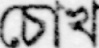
চোখ
